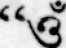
"ওঁ
